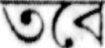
তবে
